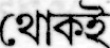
থোকই
